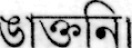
ঙাক্তনি।
